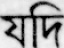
যদি
